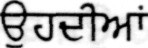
ਉਹਦੀਆਂ
